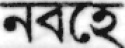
নবহে
